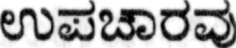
ಉಪಚಾರವು
